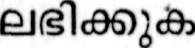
ലഭിക്കുക
